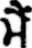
ਮੈਂ
